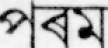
পৰম
